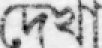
দেখা
